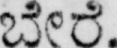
ಬೇರೆ.
